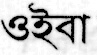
ওইবা
